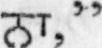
ਨਾ,''
